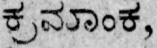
ಕ್ರಮಾಂಕ,
